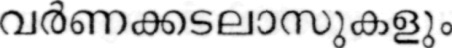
വര്‍ണക്കടലാസുകളും
